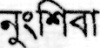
নুংশিবা
